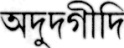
অদুদগীদি
